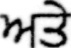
ਅਤੇ
